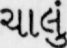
ચાલું
